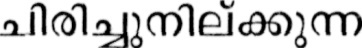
ചിരിച്ചുനില്ക്കുന്ന
